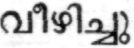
വീഴിച്ചു
